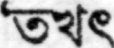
‘তখৎ
